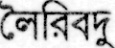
লৈরিবদু
